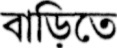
বাড়িতে
